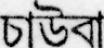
চাউবা
